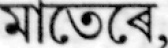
মাতেৰে,
